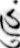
હું
